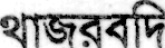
থাজরবদি
